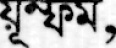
য়ূম্ফম,
